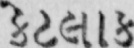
કેટલાક
